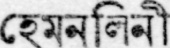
হেমনলিনী
